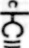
ਨੂੰ
